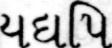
યદ્યપિ
